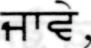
ਜਾਵੇ,
